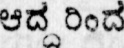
ಆದ್ದರಿಂದ
